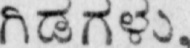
ಗಿಡಗಳು,
